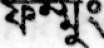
ফম্মুং
